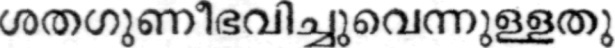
ശതഗുണീഭവിച്ചുവെന്നുള്ളതു
